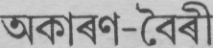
অকাৰণ-বৈৰী
